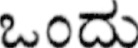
ಒಂದು
